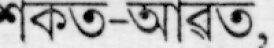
শকত-আৱত,
